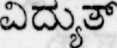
ವಿದ್ಯುತ್
